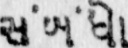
સંબંધો
